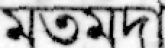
মতমদা
